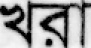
খরা
